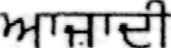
ਆਜ਼ਾਦੀ
